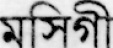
মসিগী
